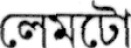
লেমটো
